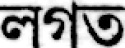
লগত
